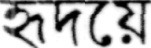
হৃদয়ে
